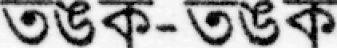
তঙক-তঙক
